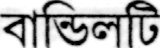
বান্ডিলটি
